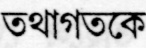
তথাগতকে
